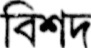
বিশদ
